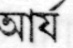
আর্য
